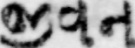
જીવન
